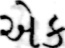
એક
